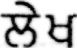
ਲੇਖ
